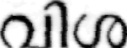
വിശ
